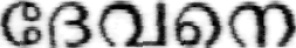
ദേവനെ
